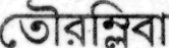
তৌরম্লিবা
